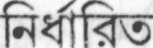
নির্ধারিত
